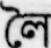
লৈ
